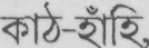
কাঠ-হাঁহি,
